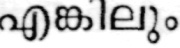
എങ്കിലും
